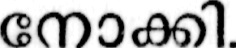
നോക്കി.
